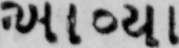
આવ્યા
